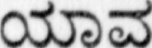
ಯಾವ
